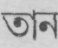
তান
